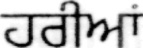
ਹਰੀਆਂ
